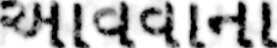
આવવાના
